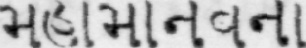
મહામાનવના
